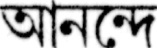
আনন্দে
